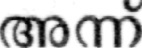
അന്ന്
